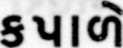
કપાળે
